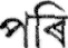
পৰি
